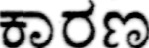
ಕಾರಣ
